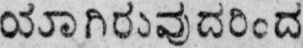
ಯಾಗಿರುವುದರಿಂದ
